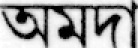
অমদা
